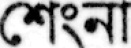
শেংনা
